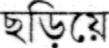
ছড়িয়ে
